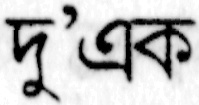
দু'এক
